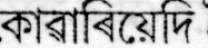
কোৱাৰিয়েদি
